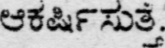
ಆಕರ್ಷಿಸುತ್ತೆ.
